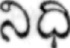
ನಿಧಿ
